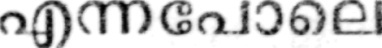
എന്നപോലെ
